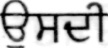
ਉਸਦੀ
